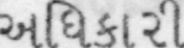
અધિકારી
